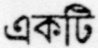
একটি
